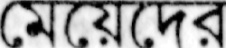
মেয়েদের
